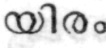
യിരം
